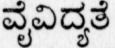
ವೈವಿದ್ಯತೆ
